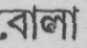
বোলা
